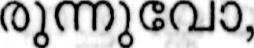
രുന്നുവോ,
